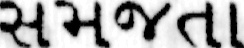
સમજતા
